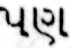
પણ
